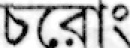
চরোং
